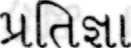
પ્રતિજ્ઞા
